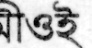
মীওই
